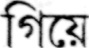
গিয়ে
